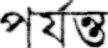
পর্যন্ত
